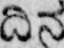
ದಿನ
